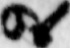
જ
